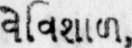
વેવિશાળ,
